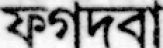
ফগদবা
